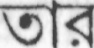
তার
